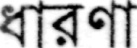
ধারণা
